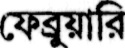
ফেব্রুয়ারি
